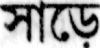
সাড়ে
